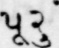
પૂરું
